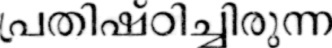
പ്രതിഷ്ഠിച്ചിരുന്ന
